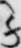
કે
